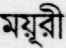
ময়ূরী
